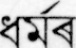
ধর্মৰ
